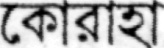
কোরাহা
